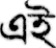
এই
